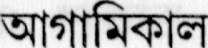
আগামিকাল
